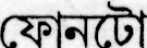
ফোনটো
